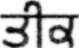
ਤੀਕ
